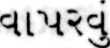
વાપરવું
